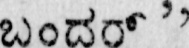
ಬಂದರ್”
